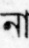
না
